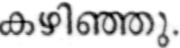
കഴിഞ്ഞു.
